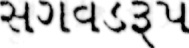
સગવડરૂપ
